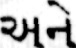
અને
